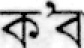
ক'ব
